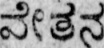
ವೇತನ
